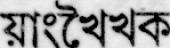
য়াংখৈখক
